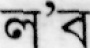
ল'ব
